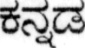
ಕನ್ನಡ
